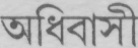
অধিবাসী
